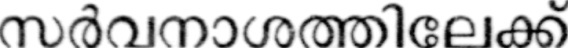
സര്‍വനാശത്തിലേക്ക്
